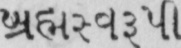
બ્રહ્માસ્વરૂપી
